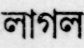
লাগল
